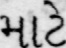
માટે
